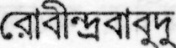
রোবীন্দ্রবাবুদু
